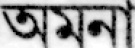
অমনা
